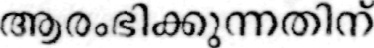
ആരംഭിക്കുന്നതിന്
